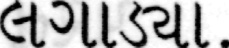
લગાડ્યા.
